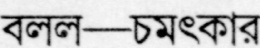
বলল–চমত্কার
